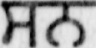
ਸਨ
